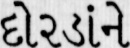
દોરડાંને
